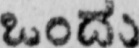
ಒಂದು
